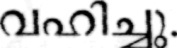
വഹിച്ചു.
